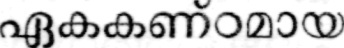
ഏകകണ്ഠമായ
